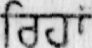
ਰਿਹਾਂ
